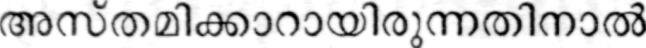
അസ്തമിക്കാറായിരുന്നതിനാല്‍
